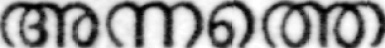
അന്നത്തെ
